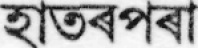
হাতৰপৰা
